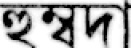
হুম্বদা
